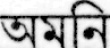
অমনি
